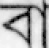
বা
